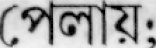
পেলায়;
